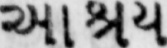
આશ્રય
